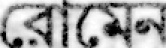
রোমেন
